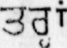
ਤਰ੍ਹਾਂ
